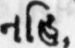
નહિ,
